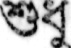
শুধু
